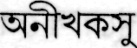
অনীখকসু
